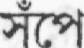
সঁপে
